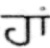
ਹਾਂ
